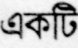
একটি
